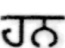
ਹਨ
